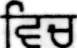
ਵਿਚ
